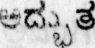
ಅದ್ಭುತ
